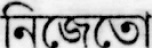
নিজেতো
